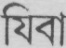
যিবা
